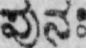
ಪುನಃ
